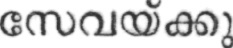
സേവയ്ക്കു
